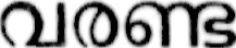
വരണ്ട
